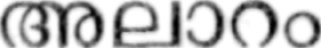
അലാറം
